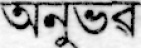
অনুভৱ
